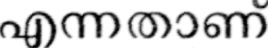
എന്നതാണ്
